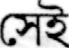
সেই
